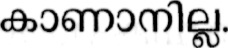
കാണാനില്ല.
